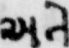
અને
